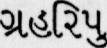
ગ્રહરિપુ
